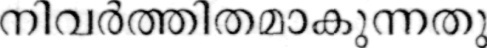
നിവര്‍ത്തിതമാകുന്നതു
